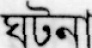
ঘটনা
